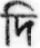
দি
